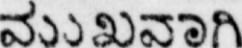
ಮುಖವಾಗಿ
